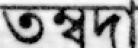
তম্বদা
